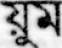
য়ুম
